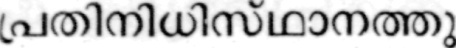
പ്രതിനിധിസ്ഥാനത്തു
